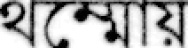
থম্মোয়
